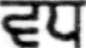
ਵਧ
